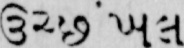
ઉચ્છખલ
